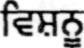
ਵਿਸ਼ਨੂ
